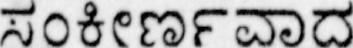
ಸಂಕೀರ್ಣವಾದ
